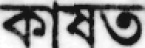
কাষত
